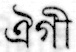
ঐগী
